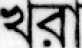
খরা
